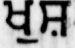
ਖੁਸ਼
